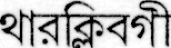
থারক্লিবগী
